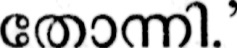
തോന്നി.’
